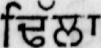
ਢਿੱਲਾ
